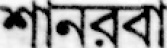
শানরবা
